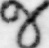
જ
